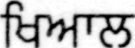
ਖਿਆਲ
